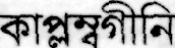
কাপ্লম্বগীনি
